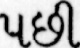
પછી
